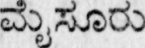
ಮೈಸೂರು
